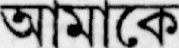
আমাকে
